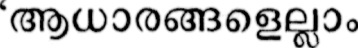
'ആധാരങ്ങളെല്ലാം
